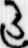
હે
